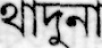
থাদুনা
